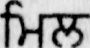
ਮਿਲ
